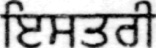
ਇਸਤਰੀ
